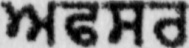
ਅਫਸਰ
